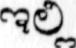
ಇಲ್ಲಿ
